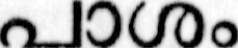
പാശം
